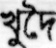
খুদৈ
